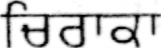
ਚਿਰਾਕਾ
